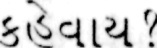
કહેવાય?
